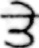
ਤੇ
